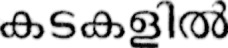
കടകളില്‍
